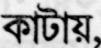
কাটায়,
